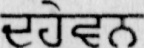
ਦਹੇਵਨ
